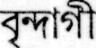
বৃন্দাগী
